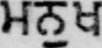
ਮਨੁਖ
